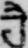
ਹੈ
